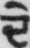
ਦੇ
